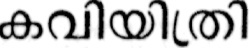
കവിയിത്രി
